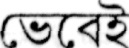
ভেবেই
